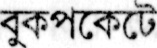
বুকপকেটে
